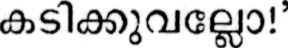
കടിക്കുവല്ലോ!’
